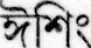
ঈশিং
